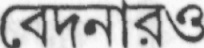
বেদনারও
